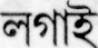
লগাই
